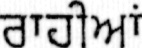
ਰਾਹੀਆਂ
